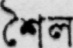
শৈল
